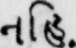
નહિ.
